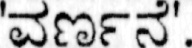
“ವರ್ಣನೆ’.
